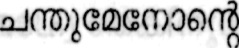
ചന്തുമേനോന്റെ
